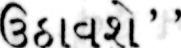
ઉઠાવશે"
